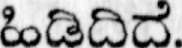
ಹಿಡಿದಿದೆ.
